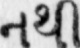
નથી
